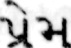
પ્રેમ
